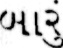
બારું
